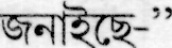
জনাইছে-"
